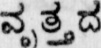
ವೃತ್ತದ
